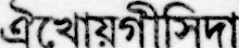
ঐখোয়গীসিদা
